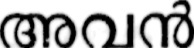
അവന്‍
